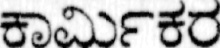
ಕಾರ್ಮಿಕರ
